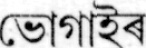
ভোগাইৰ
